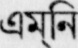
এম্‌নি
